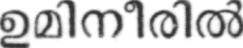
ഉമിനീരില്‍
